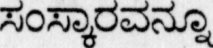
ಸಂಸ್ಕಾರವನ್ನೂ
